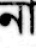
না
